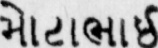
મોટાભાઈ
